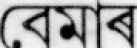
বেমাৰ
